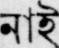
নাই
